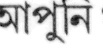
আপুনি
